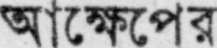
আক্ষেপের
